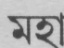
মহা
